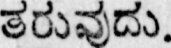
ತರುವುದು.
